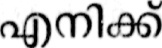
എനിക്ക്
